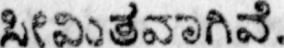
ಸೀಮಿತವಾಗಿವೆ.
